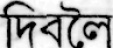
দিবলৈ
